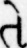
તે
